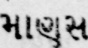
માણસ
